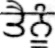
ਤੈਨੂੰ
